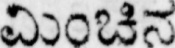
ಮಿಂಚಿನ
